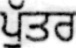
ਪੁੱਤਰ
